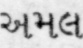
અમલ
